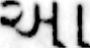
આ
